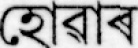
হোৱাৰ
